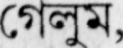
গেলুম,
